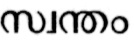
സ്വന്തം
